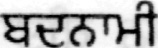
ਬਦਨਾਮੀ
